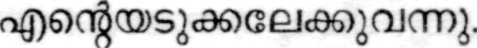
എന്റെയടുക്കലേക്കുവന്നു.
